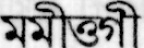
মমীত্তগী
